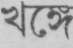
খঙ্গে
